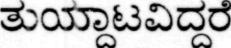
ತುಯ್ದಾಟವಿದ್ದರೆ
